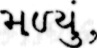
મળ્યું,
